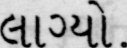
લાગ્યો.
